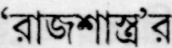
‘রাজশাস্ত্র’র
